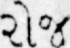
રોજ
